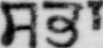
ਸਭਾ
